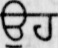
ਉਹ
